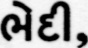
ભેદી,
